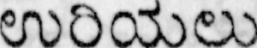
ಉರಿಯಲು
